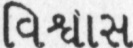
વિશ્વાસ
